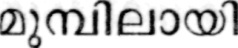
മുമ്പിലായി
